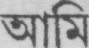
আমি
